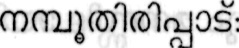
നമ്പൂതിരിപ്പാട്:
